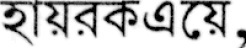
হায়রকএয়ে,
